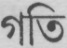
গতি
